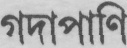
গদাপাণি
